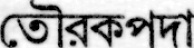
তৌরকপদা
